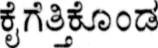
ಕೈಗೆತ್ತಿಕೊಂಡ
